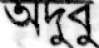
অদুবু
